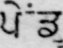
ਪੇਂਡੂ
